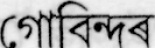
গোবিন্দৰ
